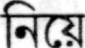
নিয়ে
